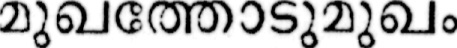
മുഖത്തോടുമുഖം
